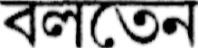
বলতেন
